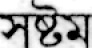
সষ্টম
